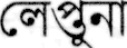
লেপ্তুনা
